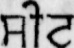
ਸੀਟ
